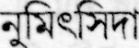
নুমিৎসিদা
